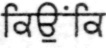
ਕਿਉਂਕਿ
